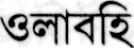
ওলাবহি
